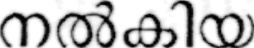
നല്‍കിയ
